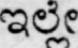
ಇಲ್ಲೇ
